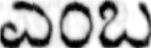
ಎಂಬ
